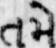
તમે
